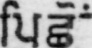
ਪਿਛੋਂ
